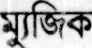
ম্যুজিক
